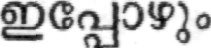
ഇപ്പോഴും
